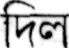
দিল
